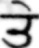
ਤੇ
